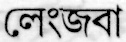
লেংজবা
